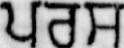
ਪਰਸ
